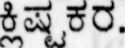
ಕ್ಲಿಷ್ಟಕರ.
